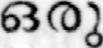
ഒരു
